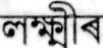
লক্ষ্মীৰ
